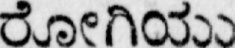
ರೋಗಿಯು
